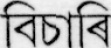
বিচাৰি
